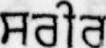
ਸਰੀਰ
